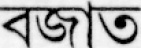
বজাত
